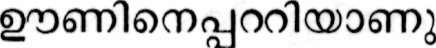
ഊണിനെപ്പററിയാണു
